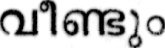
വീണ്ടും
